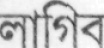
লাগিব
